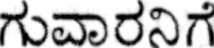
ಗುವಾರನಿಗೆ
